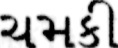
ચમકી
